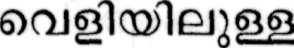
വെളിയിലുള്ള
